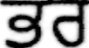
ਭਰ
